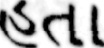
હતા
